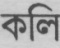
কলি
